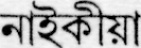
নাইকীয়া
